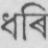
ধৰি
